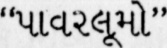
"પાવરલૂમો"
